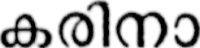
കരിനാ
